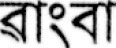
ৱাংবা
